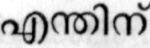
എന്തിന്
